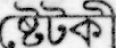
ষ্টেটকী
